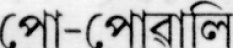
পো-পোৱালি
